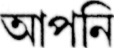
আপনি
